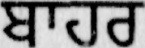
ਬਾਹਰ
